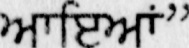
ਆਇਆਂ''
